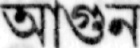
আগুন
